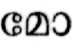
മോ
